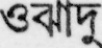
ওঝাদু
